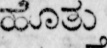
ಹೊತ್ತು
